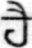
ਹੈ
